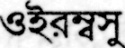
ওইরম্বসু
